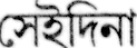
সেইদিনা
